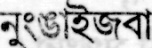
নুংঙাইজবা
